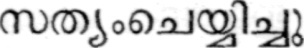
സത്യംചെയ്യിച്ചു
